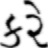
કરે
